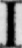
I
